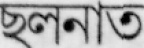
ছলনাত
